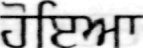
ਹੋਇਆ
